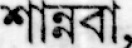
শান্নবা,
